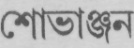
শোভাঞ্জন
